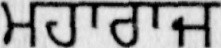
ਮਹਾਰਾਜ
